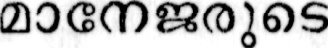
മാനേജരുടെ
